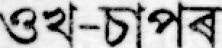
ওখ-চাপৰ
